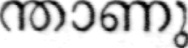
ന്താണു
